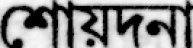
শোয়দনা
